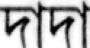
দাদা
